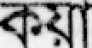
কয়া
